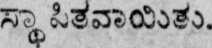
ಸ್ಥಾಪಿತವಾಯಿತು.
